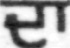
ਦਾ
